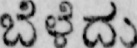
ಬೆಳೆದು
